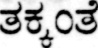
ತಕ್ಕಂತೆ
